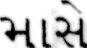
માસે
